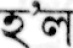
হ'ল
